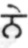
ਨੇ
